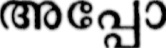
അപ്പോ
